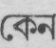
কেন
